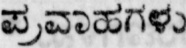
ಪ್ರವಾಹಗಳು
